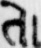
તો
